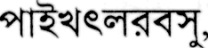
পাইখৎলরবসু,
